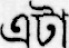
এটা
